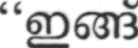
"ഇങ്ങ്
